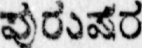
ಪುರುಷರ
